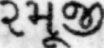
રમૂજી
